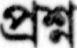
প্রশ্ন
